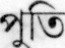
পুতি
